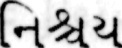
નિશ્ચય
